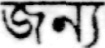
জন্য
